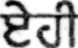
ਏਹੀ
